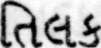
તિલક
